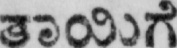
ತಾಯಿಗೆ
